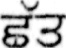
ਛੱਤ
